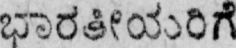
ಭಾರತೀಯರಿಗೆ
